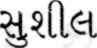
સુશીલ
